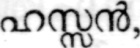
ഹസ്സന്‍,
